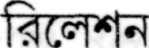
রিলেশন
